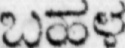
ಬಹಳ
